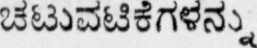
ಚಟುವಟಿಕೆಗಳನ್ನು
